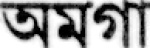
অমগা
